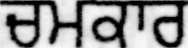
ਚਮਕਾਰ
